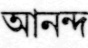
আনন্দ
